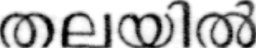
തലയില്‍
